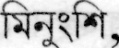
মিনুংশি,
